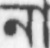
না
